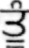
ਤੂੰ
